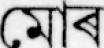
মোৰ
